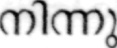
നിന്നു
